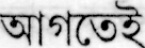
আগতেই
